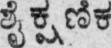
ಶೈಕ್ಷಣಿಕ
